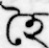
হৈ
